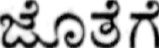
ಜೊತೆಗೆ
